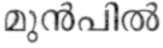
മുന്‍പില്‍
